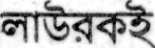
লাউরকই
